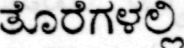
ತೊರೆಗಳಲ್ಲಿ
